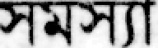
সমস্যা
